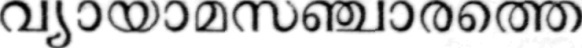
വ്യായാമസഞ്ചാരത്തെ
